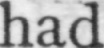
had
